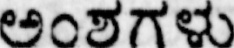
ಅಂಶಗಳು
